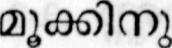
മൂക്കിനു
